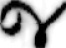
જ
